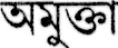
অমুক্তা
